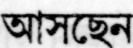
আসছেন
